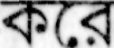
করে
